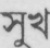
সুখ
